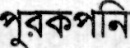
পুরকপনি
